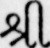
શ્રી
